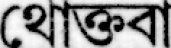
থোক্তবা
